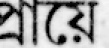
প্রায়ে
